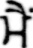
ਮੈਂ
